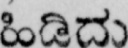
ಹಿಡಿದು
